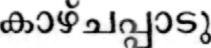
കാഴ്ചപ്പാടു
